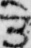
ਤੇ
